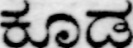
ಕೂಡ
